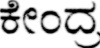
ಕೇಂದ್ರ
